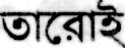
তারোই
